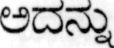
ಅದನ್ನು
